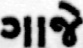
ગાજે
